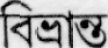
বিভ্রান্ত
